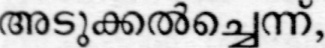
അടുക്കല്‍ച്ചെന്ന്,
